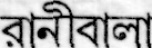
রানীবালা
